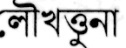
লৌখত্তুনা
